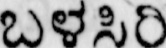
ಬಳಸಿರಿ
